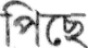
পিছে
